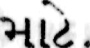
માટે.
